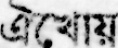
ঐখোয়
